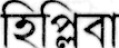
হিপ্লিবা
